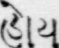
હોય
